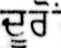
ਦੂਰੋਂ
